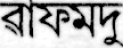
ৱাফমদু
